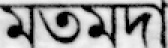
মতমদা
